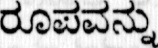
ರೂಪವನ್ನು
